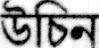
উচিন
